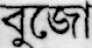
বুজো
